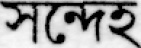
সন্দেহ
